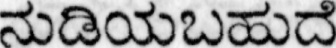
ನುಡಿಯಬಹುದೆ
